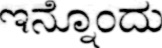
ಇನ್ನೊಂದು
